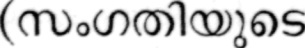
(സംഗതിയുടെ
